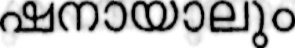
ഷനായാലും
